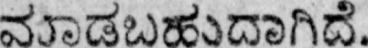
ಮಾಡಬಹುದಾಗಿದೆ.
